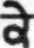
ਕੇ
